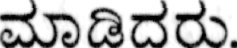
ಮಾಡಿದರು.
